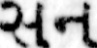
સન
